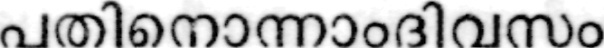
പതിനൊന്നാംദിവസം
